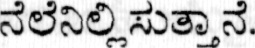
ನೆಲೆನಿಲ್ಲಿಸುತ್ತಾನೆ.
